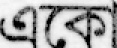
একো
